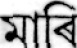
মাৰি
